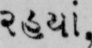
રહ્યાં,
